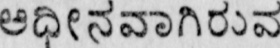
ಅಧೀನವಾಗಿರುವ
